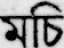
মচি
